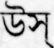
উস্
